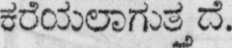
ಕರೆಯಲಾಗುತ್ತದೆ.
